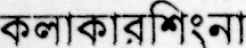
কলাকারশিংনা
